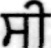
ਸੀ
